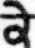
ਕੇ
